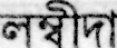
লম্বীদা
